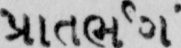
પ્રાતર્ભગં
